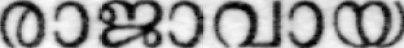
രാജാവായ
